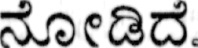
ನೋಡಿದೆ.
